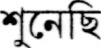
শুনেছি
